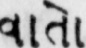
વાતો
